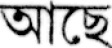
আছে
